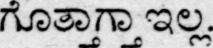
ಗೊತ್ತಾಗ್ತಾ ಇಲ್ಲ.
